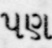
પણ
